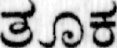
ತೂಕ
